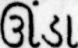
ઊંડા
